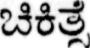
ಚಿಕಿತ್ಸೆ
